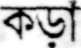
কড়া
